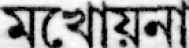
মখোয়না
